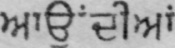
ਆਉਂਦੀਆਂ
